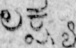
ಲಕ್ಷ್ಯ
